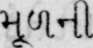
મૂળની
